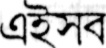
এইসব
